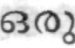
ഒരു
